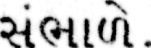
સંભાળે.
